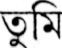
তুমি
